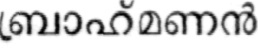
ബ്രാഹ്മണന്‍
